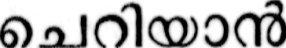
ചെറിയാന്‍
